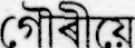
গৌৰীয়ে
